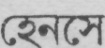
হেনসে
